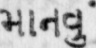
માનવું
